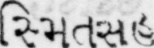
સ્મિતસહ
